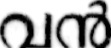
വന്‍
